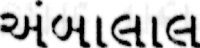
અંબાલાલ
